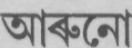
আৰুনো
